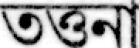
তত্তনা
